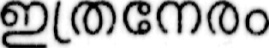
ഇത്രനേരം
